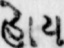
હોય
